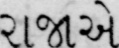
રાજાએ
